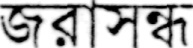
জরাসন্ধ
